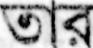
তার
